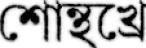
শোন্থখ্রে
